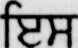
ਇਸ
